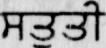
ਸਤੁਤੀ
